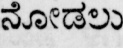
ನೋಡಲು
